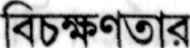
বিচক্ষণতার
